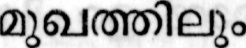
മുഖത്തിലും
